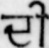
ਦੀ
